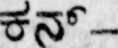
ಕನ್-
